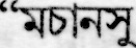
“মচানসু
